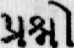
પ્રશ્નો
